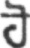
ਹੋ
